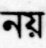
নয়
